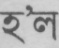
হ'ল
